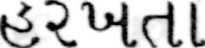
હરખતા
